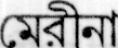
মেরীনা
